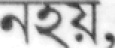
নহয়,
